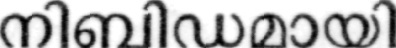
നിബിഡമായി
